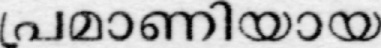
പ്രമാണിയായ
